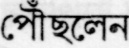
পৌঁছলেন
